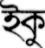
ইকু
